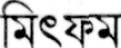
মিৎফম
